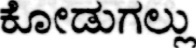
ಕೋಡುಗಲ್ಲು
